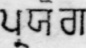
ਪ੍ਰਯੋਗ
